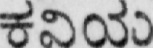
ಕವಿಯ
